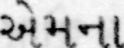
એમના
